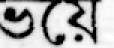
ভয়ে
